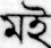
মই
